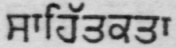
ਸਾਹਿੱਤਕਤਾ
